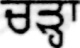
ਚੜ੍ਹਾ
